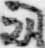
એ
